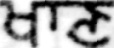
ਖਾਣ
